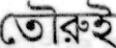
তৌরুই
